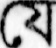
যে
